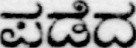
ಪಡೆದ
